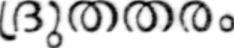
ദ്രുതതരം
